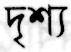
দৃশ্য
